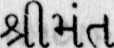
શ્રીમંત
